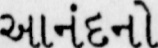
આનંદનો
